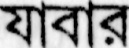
যাবার
